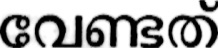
വേണ്ടത്
